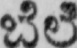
ಬೆಲೆ
